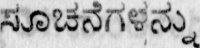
ಸೂಚನೆಗಳನ್ನು
